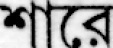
শারে
